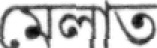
মেলাত
